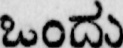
ಒಂದು
